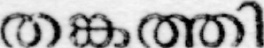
തങ്കത്തി
